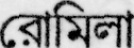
রোমিলা
